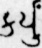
કર્યું
